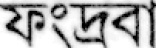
ফংদ্রবা
